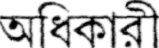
অধিকারী
